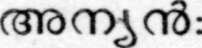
അന്യന്‍:
